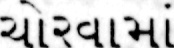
ચોરવામાં
